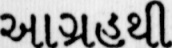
આગ્રહથી
